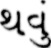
થવું
